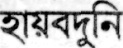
হায়বদুনি
